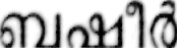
ബഷീര്‍
